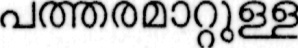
പത്തരമാറ്റുള്ള
